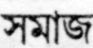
সমাজ
